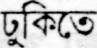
ঢুকিতে
